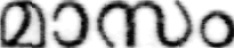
മാസം
